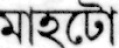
মাহটো
